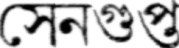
সেনগুপ্ত
